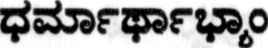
ಧರ್ಮಾಥಾ೯ಭ್ಯಾ೦
